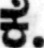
ಕೆ.
